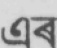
এৰ
